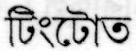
টিংটোত
